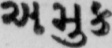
અમુક
